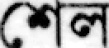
শেল
